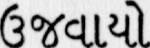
ઉજવાયો
